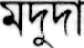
মদুদা
